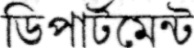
ডিপার্টমেন্ট
